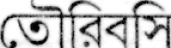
তৌরিবসি
